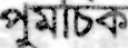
পুমচিক
